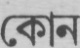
কোন
